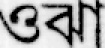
ওঝা
